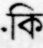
কি
